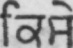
ਕਿਸੇ
